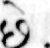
છે.
